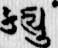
કહ્યું
